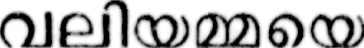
വലിയമ്മയെ
